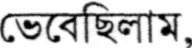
ভেবেছিলাম,
